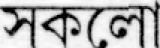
সকলো
